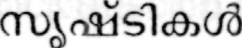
സൃഷ്ടികള്‍
